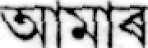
আমাৰ
